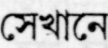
সেখানে
